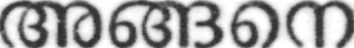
അങ്ങനെ
